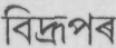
বিদ্রূপৰ
